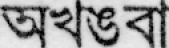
অখঙবা
